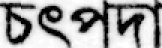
চৎপদা
